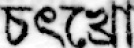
চৎখ্রো
